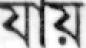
যায়
